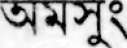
অমসুং
